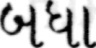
બધા
